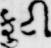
ફુટી
